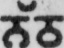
ਨੱਠ
